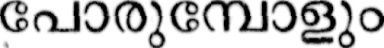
പോരുമ്പോളും
